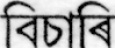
বিচাৰি
